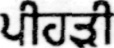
ਪੀਹੜੀ
